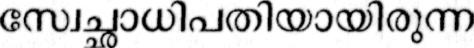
സ്വേച്ഛാധിപതിയായിരുന്ന
